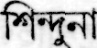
শিন্দুনা
